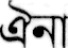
ঐনা
